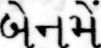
બેનમેં
